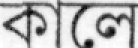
কালে
